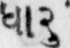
ધારું
